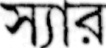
স্যার
